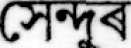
সেন্দুৰ
